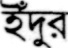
ইঁদুর
